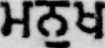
ਮਨੁਖ
